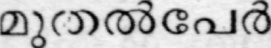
മുതല്‍പേര്‍
